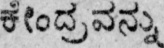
ಕೇಂದ್ರವನ್ನು
